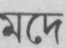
মদে
